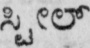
ಸ್ಟೀಲ್
